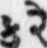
કરે
